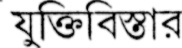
যুক্তিবিস্তার
